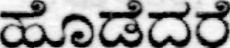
ಹೊಡೆದರೆ
